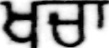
ਖਚਾ
